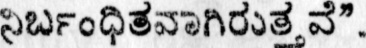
ನಿರ್ಬಂಧಿತವಾಗಿರುತ್ತವೆ”
